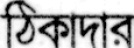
ঠিকাদার
